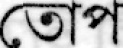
তোপ
